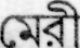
মেরী
